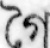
গৈ
